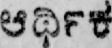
ಆರ್ಥಿಕ
